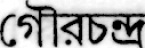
গৌরচন্দ্র
